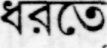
ধরতে
